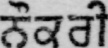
ਨੌਕਰੀ
